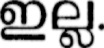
ഇല്ല.
